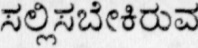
ಸಲ್ಲಿಸಬೇಕಿರುವ
